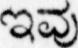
ಇವು
